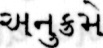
અનુક્રમે
